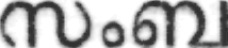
സംബ
